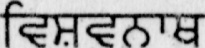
ਵਿਸ਼ਵਨਾਥ
